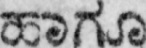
ಹಾಗೂ
